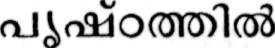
പൃഷ്ഠത്തില്‍
